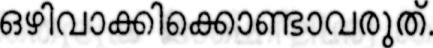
ഒഴിവാക്കിക്കൊണ്ടാവരുത്.
